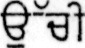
ਉੱਚੀ
